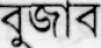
বুজাব
